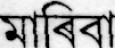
মাৰিবা
